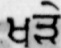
ਖੜੇ
